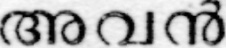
അവന്‍
